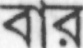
বার
